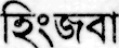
হিংজবা
